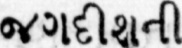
જગદીશની
